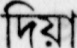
দিয়া
